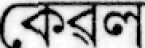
কেৱল
